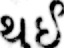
થઈ
